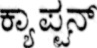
ಕ್ಯಾಪ್ಟನ್
